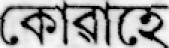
কোৱাহে
